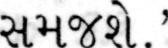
સમજશે.'
